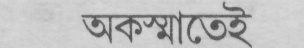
অকস্মাতেই
